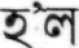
হ'ল
